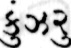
કુંઝરુ
